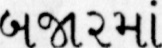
બજારમાં
